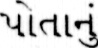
પોતાનું
